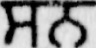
ਸਨ
